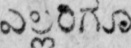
ಎಲ್ಲರಿಗೂ
